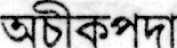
অচীকপদা
